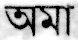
অমা
